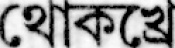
থোকখ্রে
